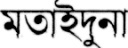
মতাইদুনা
